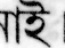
নাই
